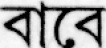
বাবে
